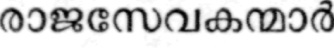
രാജസേവകന്മാര്‍
